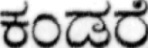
ಕಂಡರೆ
